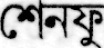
শেনফু
